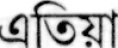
এতিয়া
